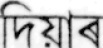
দিয়াৰ
